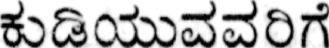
ಕುಡಿಯುವವರಿಗೆ
